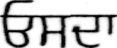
ਓਸਦਾ
